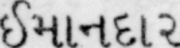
ઈમાનદાર
